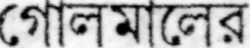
গোলমালের
